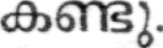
കണ്ടു.
